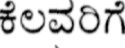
ಕೆಲವರಿಗೆ
